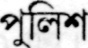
পুলিশ
